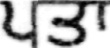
ਪਤਾ
